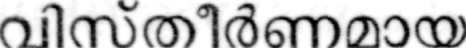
വിസ്തീര്‍ണമായ
